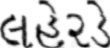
લહેરડે
